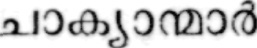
ചാക്യാന്മാര്‍
